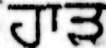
ਹਾੜ
